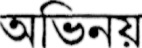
অভিনয়
